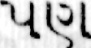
પણ
